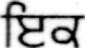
ਇਕ
